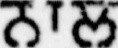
ਨਾਲ
